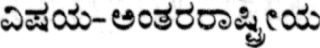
ವಿಷಯ-ಅಂತರರಾಷ್ಟ್ರೀಯ
